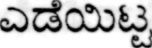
ಎಡೆಯಿಟ್ಟ
